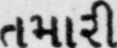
તમારી
